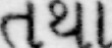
તથા
